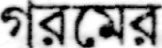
গরমের
